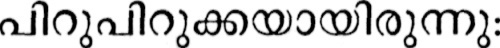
പിറുപിറുക്കയായിരുന്നു:
